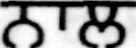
ਨਾਲ
